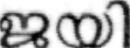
ജയി
